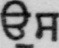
ਉਸ
